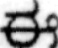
ಈ
